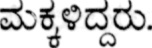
ಮಕ್ಕಳಿದ್ದರು.
